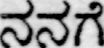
ನನಗೆ
